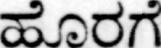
ಹೊರಗೆ
